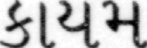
કાયમ
